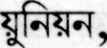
য়ুনিয়ন,
